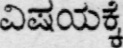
ವಿಷಯಕ್ಕೆ
